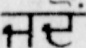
ਜਦੋਂ
